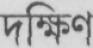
দক্ষিণ
